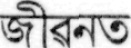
জীৱনত
